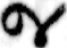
જ
